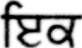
ਇਕ
